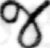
જ
